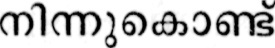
നിന്നുകൊണ്ട്
